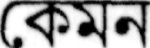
কেমন
